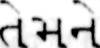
તેમને
